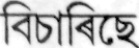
বিচাৰিছে
